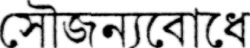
সৌজন্যবোধে
